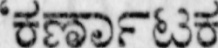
‘ಕರ್ಣಾಟಕ
